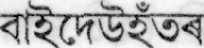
বাইদেউহঁতৰ
